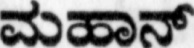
ಮಹಾನ್
